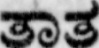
ತಾತ
